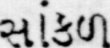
સાંકળ
